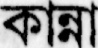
কান্না
